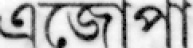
এজোপা
